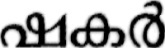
ഷകര്‍
